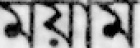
ময়াম
